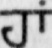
ਹਾਂ
